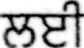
ਲਈ
